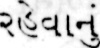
રહેવાનું
